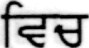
ਵਿਚ
